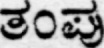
ತಂಪು
